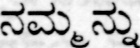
ನಮ್ಮನ್ನು
